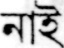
নাই
